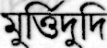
মুর্ত্তিদুদি
